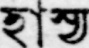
হাস্য
